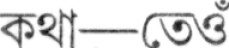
কথা-তেওঁ
